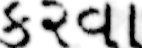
કરવા
